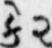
કેર
